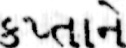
કપ્તાને
